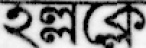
হল্লক্লে
